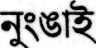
নুংঙাই
